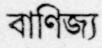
বাণিজ্য
